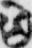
છે
